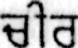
ਚੀਰ
